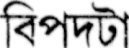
বিপদটা
